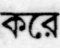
করে
